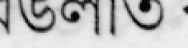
নডলাত
